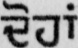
ਦੋਹਾਂ
